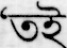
'তই
